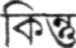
কিন্তু
